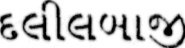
દલીલબાજી
